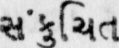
સંકુચિત
